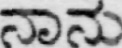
ನಾನು
